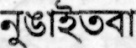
নুঙাইতবা
